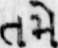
તમે
